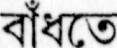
বাঁধতে
